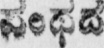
ಪಂಥದ
